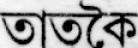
তাতকৈ
